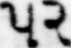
પર
